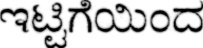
ಇಟ್ಟಿಗೆಯಿಂದ
